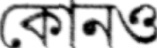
কোনও
